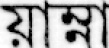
য়াম্না
